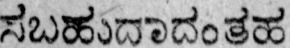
ಸಬಹುದಾದಂತಹ
